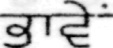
ਭਾਵੇਂ
